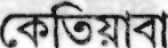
কেতিয়াবা
